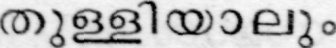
തുള്ളിയാലും
